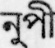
নুপী
